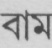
বাম
